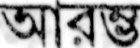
আরম্ভ
